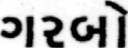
ગરબો
